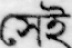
সেই
